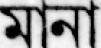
মানা
